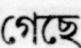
গেছে
